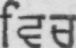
ਵਿਚ
